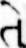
તે
